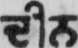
ਦੀਨ
